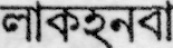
লাকহনবা
